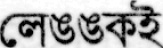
লেঙঙকই
